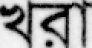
খরা
